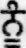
ਨੂੰ
